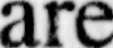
are
